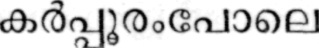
കര്‍പ്പൂരംപോലെ
